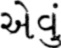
'એવું
